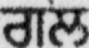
ਗਲ
